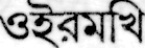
ওইরমখি
